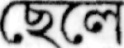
ছেলে
